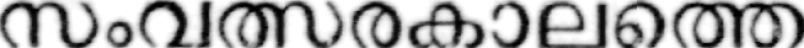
സംവത്സരകാലത്തെ
